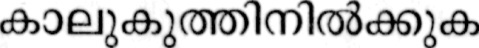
കാലുകുത്തിനില്‍ക്കുക
